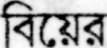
বিয়ের
